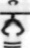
ਨੂੰ
